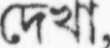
দেখা,
